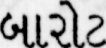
બારોટ
